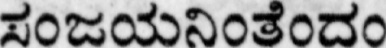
ಸಂಜಯನಿಂತೆಂದಂ
